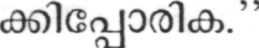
ക്കിപ്പോരിക."
